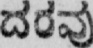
ದರವು
